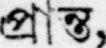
প্রান্ত,
